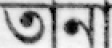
তানা
